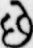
છે
